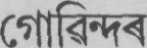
গোৱিন্দৰ
